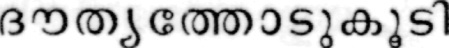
ദൌത്യത്തോടുകൂടി
